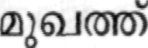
മുഖത്ത്
